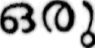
ഒരു
